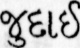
જુદાઈ
